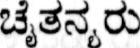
ಚೈತನ್ಯರು
